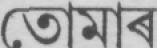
তোমাৰ
